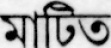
মাটিত
